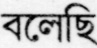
বলেছি
